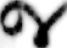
જ
